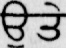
ਉਤੇ
